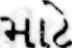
માટે
